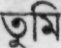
তুমি
